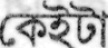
কেইটা
